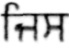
ਜਿਸ
